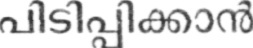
പിടിപ്പിക്കാന്‍
